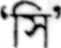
‘সি’
